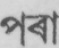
পৰা
